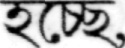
হচ্ছে,
